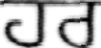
ਹਰ
